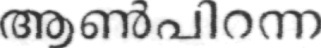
ആണ്‍പിറന്ന
